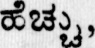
ಹೆಚ್ಚು,
